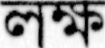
লক্ষ
